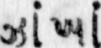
ઝાંખાં
